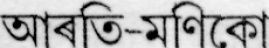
আৰতি-মণিকো
